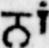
ਨਾਂ
